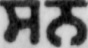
ਸਨ
